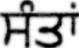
ਸੰਤਾਂ
